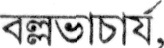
বল্লভাচার্য,
